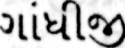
ગાંધીજી
